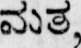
ಮತ,
